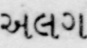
અલગ
